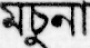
মচুনা
